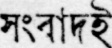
সংবাদই
